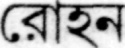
রোহন
